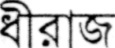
ধীরাজ
